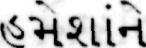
હંમેશાંને
